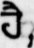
ਹੈ,
